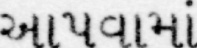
આપવામાં
